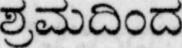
ಶ್ರಮದಿಂದ
